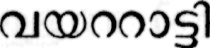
വയററാട്ടി
